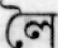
লৈ
